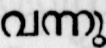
വന്നു
